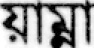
য়াম্না
